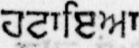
ਹਟਾਇਆ
